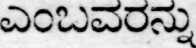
ಎಂಬವರನ್ನು
